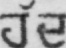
ਹੱਦ
